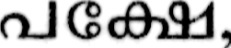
പക്ഷേ,
